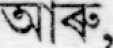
আৰু,
